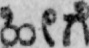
ಹೀಗೆ
